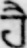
ਹੈ
